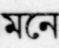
মনে
